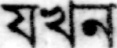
যখন
